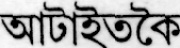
আটাইতকৈ
